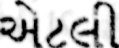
એટલી
